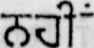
ਨਹੀਂ
